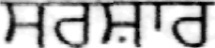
ਸਰਸ਼ਾਰ
